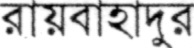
রায়বাহাদুর
